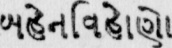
બહેનવિહોણો
